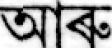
আৰু
